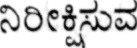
ನಿರೀಕ್ಷಿಸುವ
